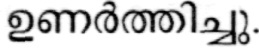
ഉണര്‍ത്തിച്ചു.
